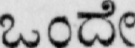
ಒಂದೇ
